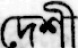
দেশী
